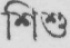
শিশু
